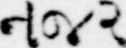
નજર
